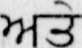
ਅਤੇ
